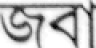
জবা
